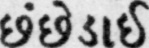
છંછેડાઈ
